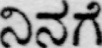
ನಿನಗೆ
